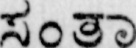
ಸಂತಾ
